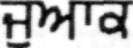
ਜੁਆਕ
